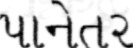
પાનેતર
